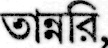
তান্নরি,
